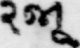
રજૂ
